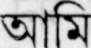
আমি
